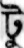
টু
